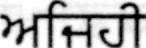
ਅਜਿਹੀ
